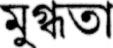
মুগ্ধতা
